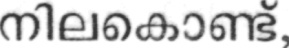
നിലകൊണ്ട്,
